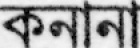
কনানা
